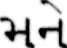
મને
